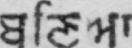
ਬਣਿਆ
